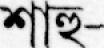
শাহু-
